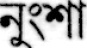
নুংশা
